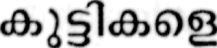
കുട്ടികളെ
